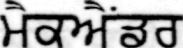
ਮੈਕਐਂਡਰ
